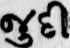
જુદી
